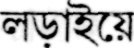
লড়াইয়ে
